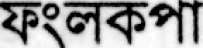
ফংলকপা
